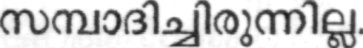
സമ്പാദിച്ചിരുന്നില്ല.
